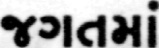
જગતમાં
